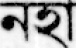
নহা
